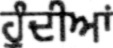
ਹੁੰਦੀਆਂ
